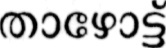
താഴോട്ട്
